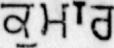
ਕੁਮਾਰ
